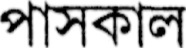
পাসকাল
